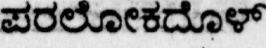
ಪರಲೋಕದೊಳ್
